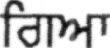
ਗਿਆ
